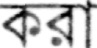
করা
